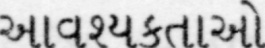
આવશ્યકતાઓ
